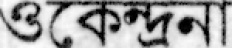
ওকেন্দ্রনা
